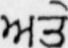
ਅਤੇ
